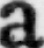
a
